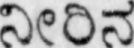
ನೀರಿನ
